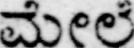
ಮೇಲೆ
